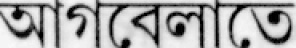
আগবেলাতে
